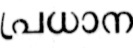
പ്രധാന
